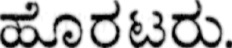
ಹೊರಟರು.
